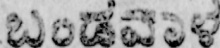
ಬಂಡವಾಳ
